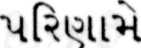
પરિણામે
